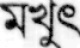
মখুৎ
